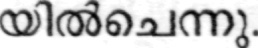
യില്‍ചെന്നു.
